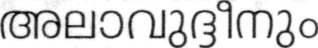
അലാവുദ്ദീനും
